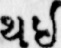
થઈ
